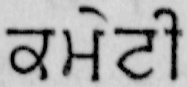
ਕਮੇਟੀ
